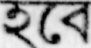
হবে
